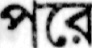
পরে
